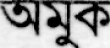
অমুক
